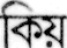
কিয়
